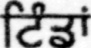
ਟਿੰਡਾਂ
